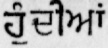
ਹੁੰਦੀਆਂ
